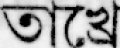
তাখ্রে
